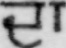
ਦਾ
